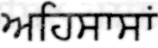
ਅਹਿਸਾਸਾਂ
